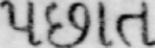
પછાત
